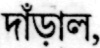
দাঁড়াল,
